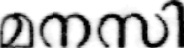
മനസി
